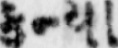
કન્યા
